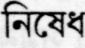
নিষেধ
